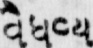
વૈધવ્ય
